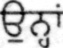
ਉਨ੍ਹਾਂ
